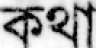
কথা
